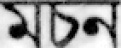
মচন
